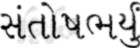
સંતોષભર્યું
